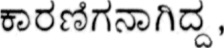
ಕಾರಣಿಗನಾಗಿದ್ದ,
